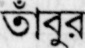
তাঁবুর
